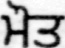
ਮੌਤ
